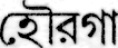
হৌরগা
